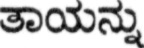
ತಾಯನ್ನು
